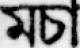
মচা
